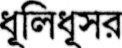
ধূলিধূসর
